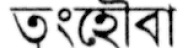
তূংহৌবা
